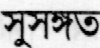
সুসঙ্গত
